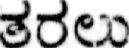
ತರಲು
